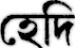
হেদি
